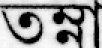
তম্না
